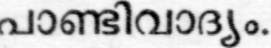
പാണ്ടിവാദ്യം.
